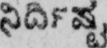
ನಿರ್ದಿಷ್ಟ
